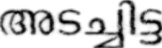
അടച്ചിട്ട
